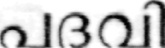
പദവി
